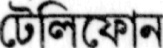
টেলিফোন
